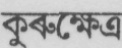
কুৰুক্ষেত্ৰ
